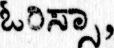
ಓರಿಸ್ಸಾ,
